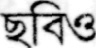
ছবিও
